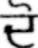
ਦੋ
